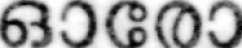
ഓരോ
